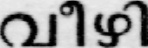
വീഴി
